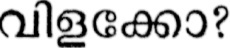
വിളക്കോ?
